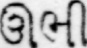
ઊભી
